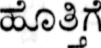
ಹೊತ್ತಿಗೆ
